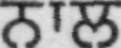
ਨਾਲ
